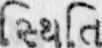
સ્થિતિ
